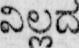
ವಿಲ್ಲದ
